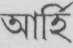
আৰ্হি
